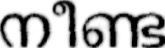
നീണ്ട
